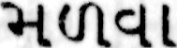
મળવા
